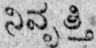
ನಿವೃತ್ತಿ
